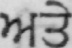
ਅਤੇ
